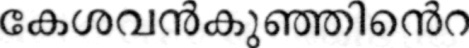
കേശവന്‍കുഞ്ഞിന്റെ
